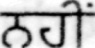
ਨਹੀਂ
